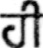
ਹੀ
